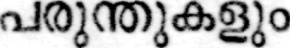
പരുന്തുകളും
